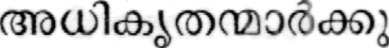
അധികൃതന്മാര്‍ക്കു
